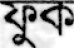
ফুক
